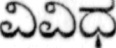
ವಿವಿಧ
